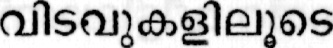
വിടവുകളിലൂടെ
